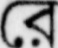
রে
